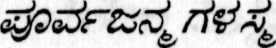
ಪೂರ್ವಜನ್ಮಗಳಸ್ಮ
